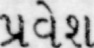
પ્રવેશ
